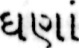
ઘણાં
